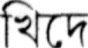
খিদে
